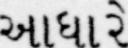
આધારે
